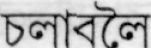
চলাবলৈ
